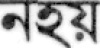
নহয়
